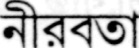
নীরবতা
